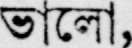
ভালো,
